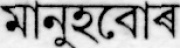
মানুহবোৰ
